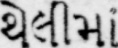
થેલીમાં
